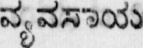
ವ್ಯವಸಾಯ
